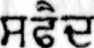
ਸਫੈਦ
